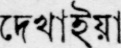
দেখাইয়া
